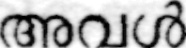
അവള്‍
